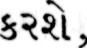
કરશે,
